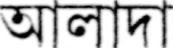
আলাদা
